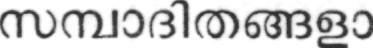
സമ്പാദിതങ്ങളാ
